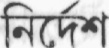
নির্দেশ
